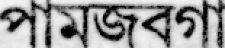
পামজবগা
